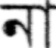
না
